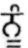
ਨੂੰ
